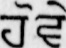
ਹੋਵੇ
